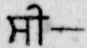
ਸੀ-
